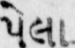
પેલા
